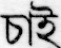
চাই
